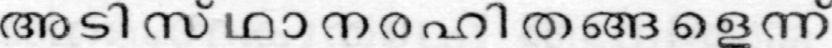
അടിസ്ഥാനരഹിതങ്ങളെന്ന്
